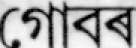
গোবৰ
